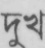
দুখ
